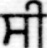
ਸੀ
